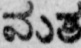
ಮತ
